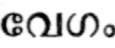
വേഗം
